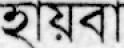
হায়বা
